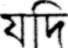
যদি
